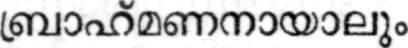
ബ്രാഹ്മണനായാലും
